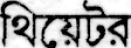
থিয়েটর
